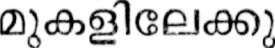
മുകളിലേക്കു
